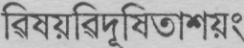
ৱিষয়ৱিদূষিতাশয়ং
